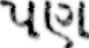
પણ
